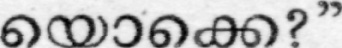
യൊക്കെ?"
